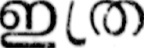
ഇത്ര
